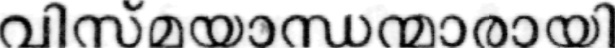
വിസ്മയാന്ധന്മാരായി
